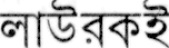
লাউরকই
